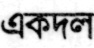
একদল
